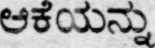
ಆಕೆಯನ್ನು
